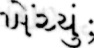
ખેંચ્યું;
